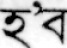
হ'ব
